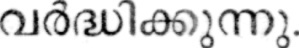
വര്‍ദ്ധിക്കുന്നു.
